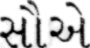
સૌએ
